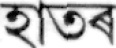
হাতৰ
